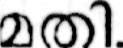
മതി.
